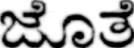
ಜೊತೆ
